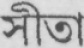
সীতা
